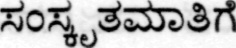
ಸಂಸ್ಕೃತಮಾತಿಗೆ
